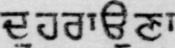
ਦੁਹਰਾਉਣਾ
